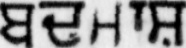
ਬਦਮਾਸ਼
